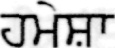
ਹਮੇਸ਼ਾ
